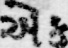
એક
